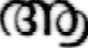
ആ
